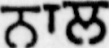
ਨਾਲ
